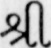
શ્રી
